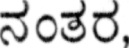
ನಂತರ,
